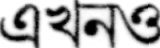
এখনও
